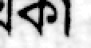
থকা
